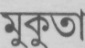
মুকুতা
